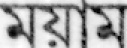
ময়াম
